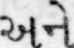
અને
